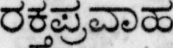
ರಕ್ತಪ್ರವಾಹ
